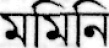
মমিনি
